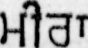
ਮੀਰਾ
